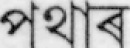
পথাৰ
